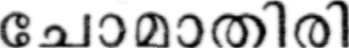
ചോമാതിരി
